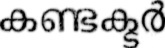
കണ്ടക്ടര്‍
